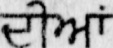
ਦੀਆਂ
